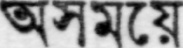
অসময়ে
